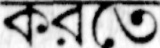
করতে
